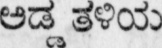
ಅಡ್ಡತಳಿಯ
